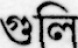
গুলি
